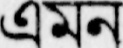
এমন
